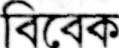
বিবেক
